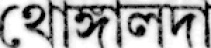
থোঙ্গালদা
